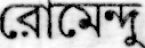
রোমেন্দু
